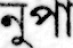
নুপা
